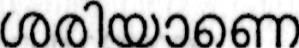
ശരിയാണെ
